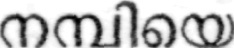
നമ്പിയെ
